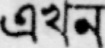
এখন
